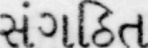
સંગઠિત
